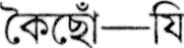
কৈছোঁ-যি
